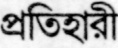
প্রতিহারী
